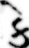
કે
